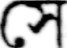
সে
